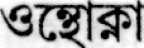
ওন্থোক্না
